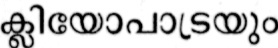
ക്ലിയോപാട്രയും
